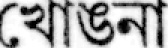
খোঙনা
